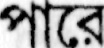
পারে
